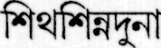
শিথশিন্নদুনা
